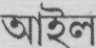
আইল
